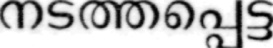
നടത്തപ്പെട്ട
